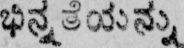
ಭಿನ್ನತೆಯನ್ನು
